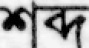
শব্দ
